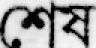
শেষ
